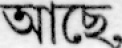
আছে,
